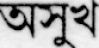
অসুখ
